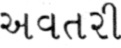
અવતરી
